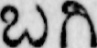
ಬಗಿ
